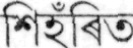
শিহঁৰিত
